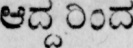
ಆದ್ದರಿಂದ
